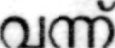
വന്ന്
